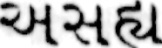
અસહ્ય
